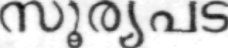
സൂര്യപട
